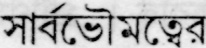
সার্বভৌমত্বের
